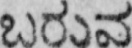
ಬರುವ
